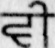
ਵੀ
